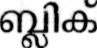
ബ്ലിക്
